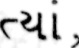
ત્યાં,
